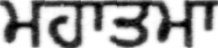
ਮਹਾਤਮਾ
